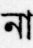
না
